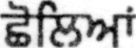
ਛੋਲਿਆਂ
